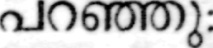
പറഞ്ഞു:
